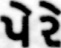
પેરે
